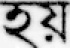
হয়
